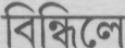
বিন্ধিলে
